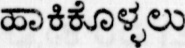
ಹಾಕಿಕೊಳ್ಳಲು
